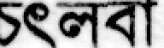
চৎলবা
